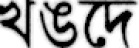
খঙদে
